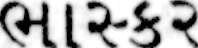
ભાસ્કર
